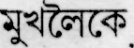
মুখলৈকে
